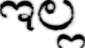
ಇಲ್ಲ
